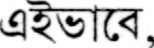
এইভাবে,
